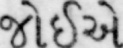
જોઈએ
